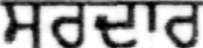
ਸਰਦਾਰ
